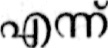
എന്ന്
